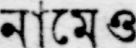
নামেও
